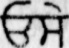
ਓਸੇ
